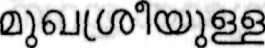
മുഖശ്രീയുള്ള
